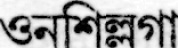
ওনশিল্লগা
